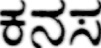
ಕನಸ
